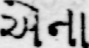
એના
